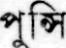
পুন্সি
